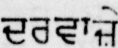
ਦਰਵਾਜ਼ੇ
